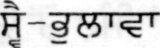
ਸ੍ਵੈ-ਭੁਲਾਵਾ
